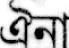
ঐনা
